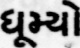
ધૂમ્યો
